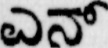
ಎನ್
